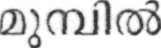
മുമ്പില്‍
